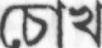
চোখ
